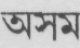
অসম
